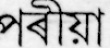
পৰীয়া
